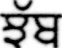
ਝੱਬ
